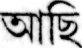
আছি
